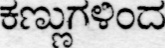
ಕಣ್ಣುಗಳಿಂದ
